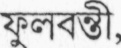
ফুলবন্তী,
